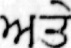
ਅਤੇ
